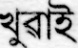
খুৱাই
